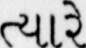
ત્યારે
